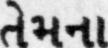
તેમના
